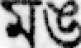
মঙ
